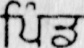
ਪਿੰਡ
